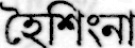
হৈশিংনা
